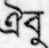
ঐবু
